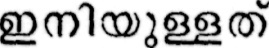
ഇനിയുള്ളത്
